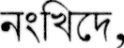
নংখিদে,
